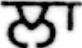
ਲਾ
